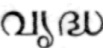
വൃദ്ധ
